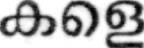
കളെ
